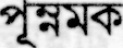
পূম্নমক
